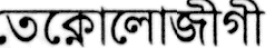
তেক্নোলোজীগী
